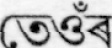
তেওঁৰ
